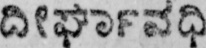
ದೀರ್ಘಾವಧಿ
